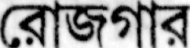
রোজগার
